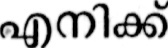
എനിക്ക്
